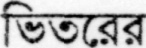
ভিতরের
